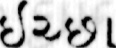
ઈચ્છા
